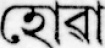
হোৱা
